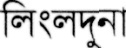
লিংলদুনা
